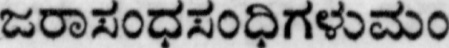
ಜರಾಸಂಧಸಂಧಿಗಳುಮಂ
